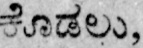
ಕೊಡಲು,
